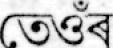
তেওঁৰ
